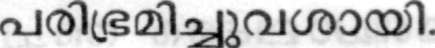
പരിഭ്രമിച്ചുവശായി.
